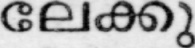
ലേക്കു
